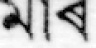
মাৰ
